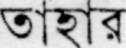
তাহার
